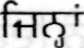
ਜਿਨ੍ਹਾਂ
